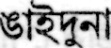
ঙাইদুনা
